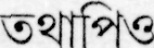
তথাপিও
